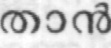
താന്‍
